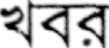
খবর
